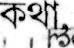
কথা,
